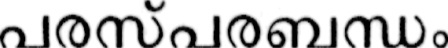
പരസ്പരബന്ധം
